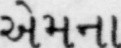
એમના
